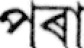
পৰা
